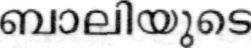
ബാലിയുടെ
